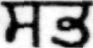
ਸਭ
